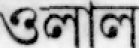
ওলাল
